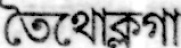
তৈথোক্লগা
